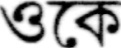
ওকে
